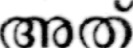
അത്
